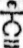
ਨੂੰ
